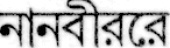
নানবীররে
